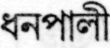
ধনপালী
